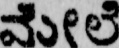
ಮೇಲೆ
